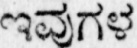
ಇವುಗಳ
